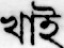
খাই
